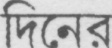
দিনের
